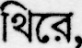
থিরে,
